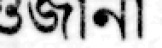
ওজানা
